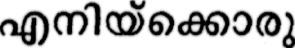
എനിയ്ക്കൊരു
